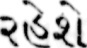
રહેશે
